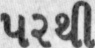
પરથી
